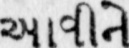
આવીને
